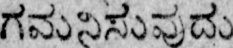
ಗಮನಿಸುವುದು
